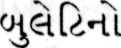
બુલેટિનો
